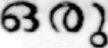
ഒരു
